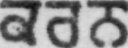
ਕਰਨ
